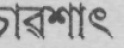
চাৱশাৎ
